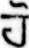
ਹੋ
